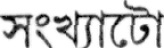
সংখ্যাটো
